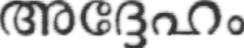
അദ്ദേഹം
